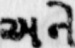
અને
